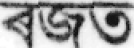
ৰজত
